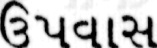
ઉપવાસ
